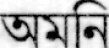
অমনি
